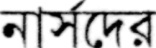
নার্সদের
